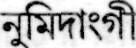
নুমিদাংগী
